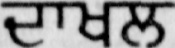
ਦਾਖਲ
